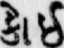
કોઈ
